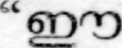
“ഈ
